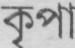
কৃপা
